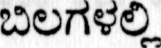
ಬಿಲಗಳಲ್ಲಿ
